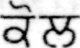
ਕੋਲ
